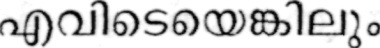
എവിടെയെങ്കിലും
